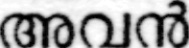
അവന്‍
